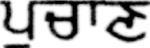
ਪੁਚਾਣ
